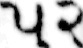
પર
